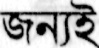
জন্যই
